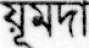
য়ূমদা
